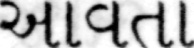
આવતા
